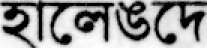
হালেঙদে
